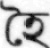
হৈ
